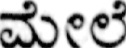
ಮೇಲೆ
